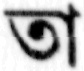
তা
